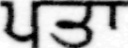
ਪਤਾ
